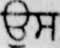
ਉਸ
